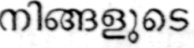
നിങ്ങളുടെ
